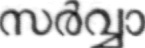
സര്‍വ്വാ
